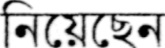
নিয়েছেন
